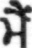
ਮੈਂ
